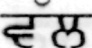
ਵੱਲ
